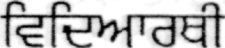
ਵਿਦਿਆਰਥੀ
